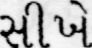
સીખે
